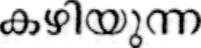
കഴിയുന്ന
